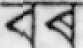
বৰ
